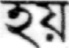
হয়
